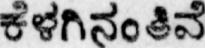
ಕೆಳಗಿನಂತಿವೆ
